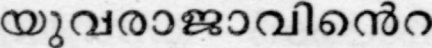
യുവരാജാവിന്റെ
